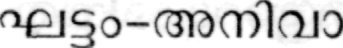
ഘട്ടം-അനിവാ
